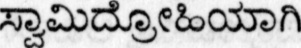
ಸ್ವಾಮಿದ್ರೋಹಿಯಾಗಿ
